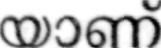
യാണ്
